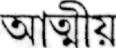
আত্মীয়
